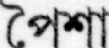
পৈশা
